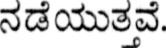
ನಡೆಯುತ್ತವೆ.
